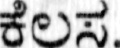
ಕೆಲಸ.
